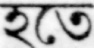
হতে
